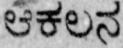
ಅಕಲನ
